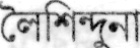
লৈশিন্দুনা
